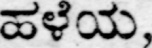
ಹಳೆಯ,
